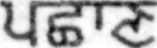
ਪਛਾਣ
